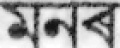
মনৰ
